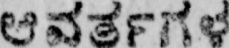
ಆವರ್ತಗಳ
